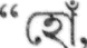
"হোঁ,
